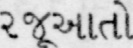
રજૂઆતો
